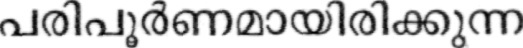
പരിപൂര്‍ണമായിരിക്കുന്ന
